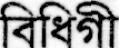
বিধিগী
